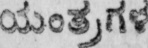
ಯಂತ್ರಗಳ
